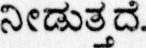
ನೀಡುತ್ತದೆ.
